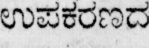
ಉಪಕರಣದ
